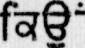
ਕਿਉਂ
